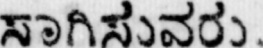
ಸಾಗಿಸುವರು.
